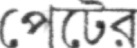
পেটের
